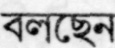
বলছেন
